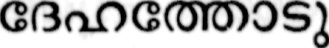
ദേഹത്തോടു
